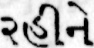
રહીને
